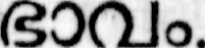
ഭാവം.
